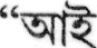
"আই
